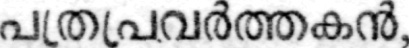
പത്രപ്രവര്‍ത്തകന്‍,
